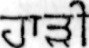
ਹਾੜੀ
